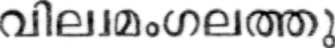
വില്വമംഗലത്തു
